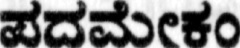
ಪದಮೇಕಂ
